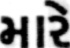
મારે
